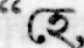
“হে,
